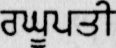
ਰਘੂਪਤੀ
